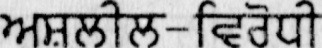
ਅਸ਼ਲੀਲ-ਵਿਰੋਧੀ
